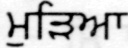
ਮੁੜਿਆ
